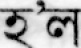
হ'ল
